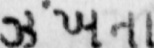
ઝંખના
